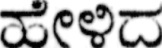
ಹೇಳಿದ
